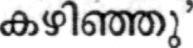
കഴിഞ്ഞു’
